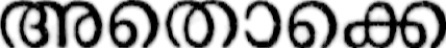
അതൊക്കെ
